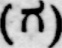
(ಗ)
